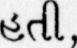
હતી,
